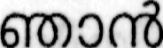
ഞാന്‍
